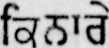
ਕਿਨਾਰੇ
